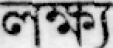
লক্ষ্য
